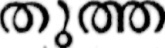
തുത്ത
